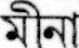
মীনা
